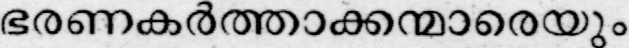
ഭരണകര്‍ത്താക്കന്മാരെയും
